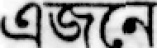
এজনে
